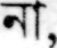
না,
